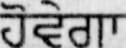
ਹੋਵੇਗਾ
